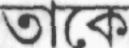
তাকে
